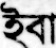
ইবা
